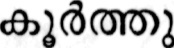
കൂര്‍ത്തു
